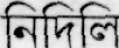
নিদিলি
